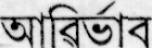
আৱির্ভাব
